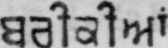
ਬਰੀਕੀਆਂ
